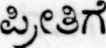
ಪ್ರೀತಿಗೆ
